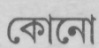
কোনো
